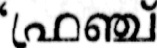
‘ഫ്രഞ്ച്
